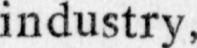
industry,
